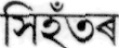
সিহঁতৰ
